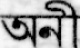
অনী
